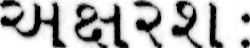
અક્ષરશઃ
